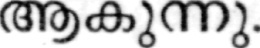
ആകുന്നു.
